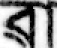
ৱা
